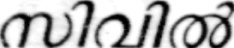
സിവില്‍
